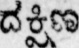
ದಕ್ಷಿಣ
